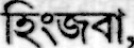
হিংজবা,
